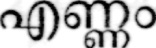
എണ്ണം
